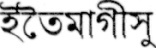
ইতৈমাগীসু
